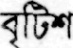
বৃটিশ
